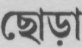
ছোড়া
